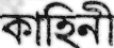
কাহিনী
